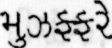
મુઝફ્ફરે
